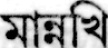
মান্নখি
